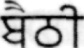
ਬੈਠੀ
